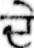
ਦੇ
